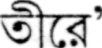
তীরে’
